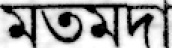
মতমদা
